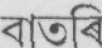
বাতৰি
